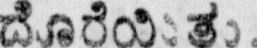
ದೊರೆಯಿತು.
